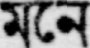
মনে
